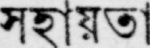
সহায়তা
